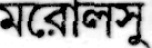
মরোলসু
